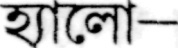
হ্যালো-
